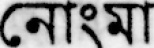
নোংমা
